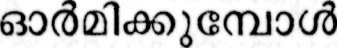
ഓര്‍മിക്കുമ്പോള്‍
